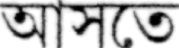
আসতে
